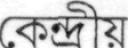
কেন্দ্রীয়
